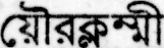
য়ৌরক্লম্মী
